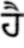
ਹੈ
